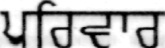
ਪਰਿਵਾਰ
